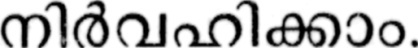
നിര്‍വഹിക്കാം.
